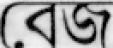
বেজ
